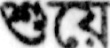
শুয়ে
